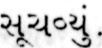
સૂચવ્યું.
